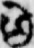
છે
